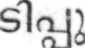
ടിപ്പു
